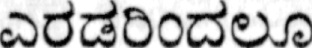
ಎರಡರಿಂದಲೂ
